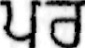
ਪਰ
